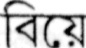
বিয়ে
